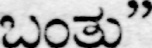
ಬಂತು”
